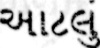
આટલું
